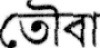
তৌবা
